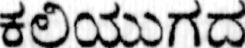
ಕಲಿಯುಗದ
